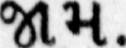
જામ.
